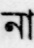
না
